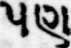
પણ
